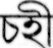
চহী
